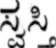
ಸ್ವಸ್ತಿ
